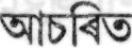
আচৰিত
